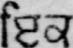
ਇਕ
